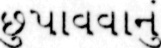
છુપાવવાનું
